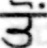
ਤੋਂ
